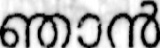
ഞാന്‍
